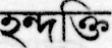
হন্দক্তি
